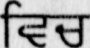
ਵਿਚ
